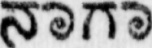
ನಾಗಾ
